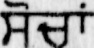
ਸੋਚਾਂ
